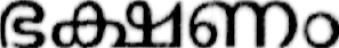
ഭക്ഷണം
